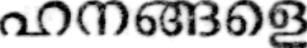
ഹനങ്ങളെ
